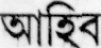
আহিব
